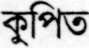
কুপিত
